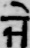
ਜੇ
